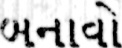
બનાવો
